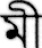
মী
